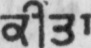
ਕੀਤਾ
